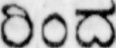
ರಿಂದ
